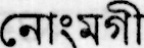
নোংমগী
